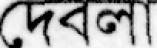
দেবলা
